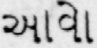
આવો
